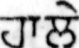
ਹਾਲੇ
